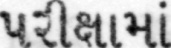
પરીક્ષામાં
